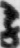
કે
